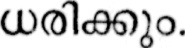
ധരിക്കും.
